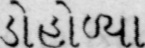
ડોહોળ્યા
